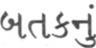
બતકનું
